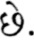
છે.
